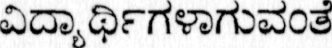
ವಿದ್ಯಾರ್ಥಿಗಳಾಗುವಂತೆ
